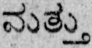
ಮತ್ತು
